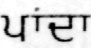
ਪਾਂਦਾ
